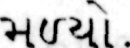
મળ્યો.
